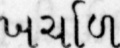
ખર્ચાળ
